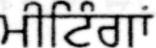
ਮੀਟਿੰਗਾਂ
